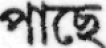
পাছে
